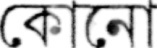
কোনো
